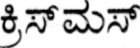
ಕ್ರಿಸ್ಮಸ್
